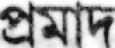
প্ৰমাদ
